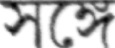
সঙ্গে
